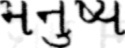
મનુષ્ય
